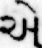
એ
